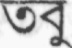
তবু
